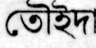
তৌইদা
